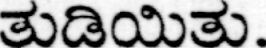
ತುಡಿಯಿತು.
